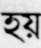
হয়
